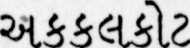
અકકલકોટ
